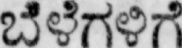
ಬೆಳೆಗಳಿಗೆ
